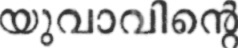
യുവാവിന്റെ
